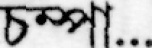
চম্পা...
